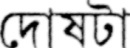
দোষটা
